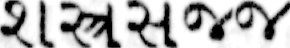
શસ્ત્રસજ્જ
